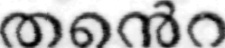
തന്റെ
